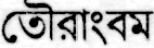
তৌরাংবম
